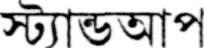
স্ট্যান্ডআপ
